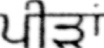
ਪੀੜਾਂ
